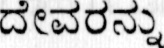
ದೇವರನ್ನು
